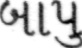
બાપુ
